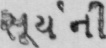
સૂર્યની
